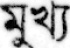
মুখ্য
